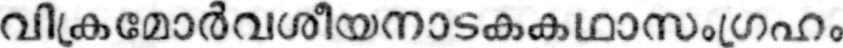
വിക്രമോര്‍വശീയനാടകകഥാസംഗ്രഹം
